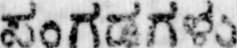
ಪಂಗಡಗಳು
